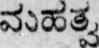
ಮಹತ್ವ
